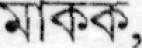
মাকক,
